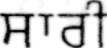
ਸਾਰੀ
